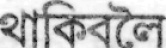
থাকিবলৈ
